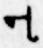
ન
